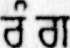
ਰੰਗ
